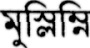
মুস্লিম্নি
